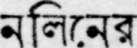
নলিনের
